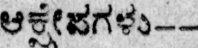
ಆಕ್ಷೇಪಗಳು--
